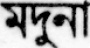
মদুনা
